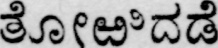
ತೋಱಿದಡೆ
